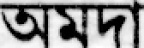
অমদা
